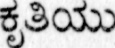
ಕೃತಿಯು
